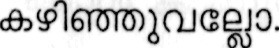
കഴിഞ്ഞുവല്ലോ.
